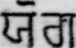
ਯੋਗ
